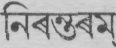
নিৰন্তৰম্
